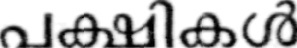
പക്ഷികള്‍
